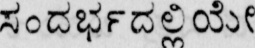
ಸಂದರ್ಭದಲ್ಲಿಯೇ
